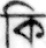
কি
